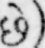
છે)
